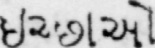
ઇચ્છાઓ
